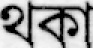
থকা
